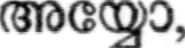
അയ്യോ,
